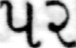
પર
